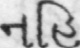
નહિ
